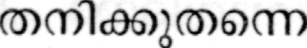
തനിക്കുതന്നെ
